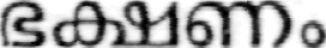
ഭക്ഷണം
